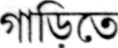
গাড়িতে
